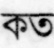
কত
